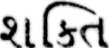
શક્તિ
